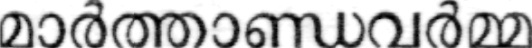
മാര്‍ത്താണ്ഡവര്‍മ്മ
